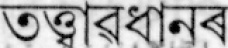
তত্ত্বাৱধানৰ
